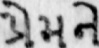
પ્રેમને
